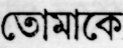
তোমাকে
